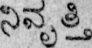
ನಿವೃತ್ತಿ
